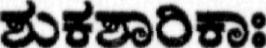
ಶುಕಶಾರಿಕಾಃ
